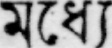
মধ্যে
